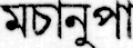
মচানুপা
